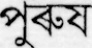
পুৰুষ
